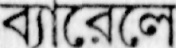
ব্যারেলে
